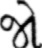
જો
